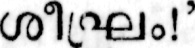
ശീഘ്രം!'
